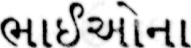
ભાઈઓના
